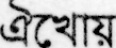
ঐখোয়
